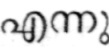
എന്നു
